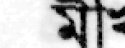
মীখ
